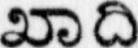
ಖಾದಿ
